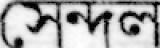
সেন্দল
